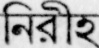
নিরীহ
